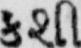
કશી
